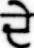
ਦੇ
